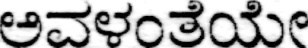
ಅವಳಂತೆಯೇ
